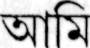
আমি
